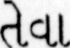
તેવા
